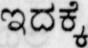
ಇದಕ್ಕೆ
